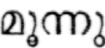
മൂന്നു
